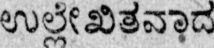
ಉಲ್ಲೇಖಿತವಾದ
